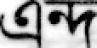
এন্দ
